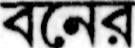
বনের
